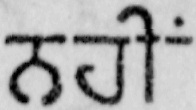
ਨਹੀਂ
